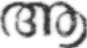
ആ
